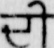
ਦੀ
